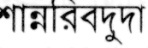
শান্নরিবদুদা
